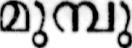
മുമ്പു
